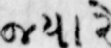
જ્યારે
